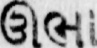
ઊભા
